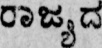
ರಾಜ್ಯದ
